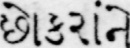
છોકરાંને
